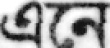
এনে
